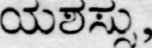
ಯಶಸ್ಸು,
